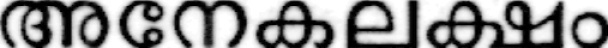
അനേകലക്ഷം
